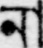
না
